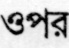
ওপর
